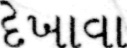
દેખાવા
